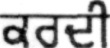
ਕਰਦੀ
